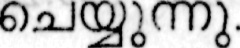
ചെയ്യുന്നു.
